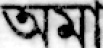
অমা
